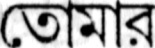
তোমার
